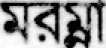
মরম্না
